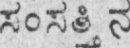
ಸಂಸತ್ತಿನ
